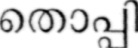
തൊപ്പി
